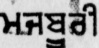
ਮਜਬੂਰੀ
